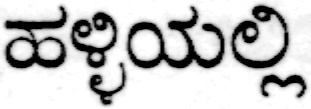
ಹಳ್ಳಿಯಲ್ಲಿ
